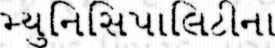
મ્યુનિસિપાલિટીના
